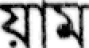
য়াম
